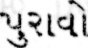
પુરાવો
